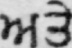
ਅਤੇ
